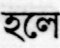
হলে
